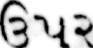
ઉપર
